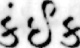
કંઈક
